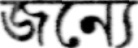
জন্যে
